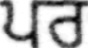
ਪਰ
